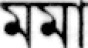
মমা
